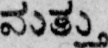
ಮತ್ತು
